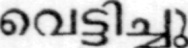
വെട്ടിച്ചു
